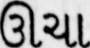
ઊચા
